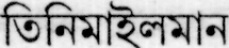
তিনিমাইলমান
